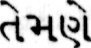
તેમણે
